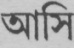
আসি
